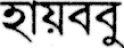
হায়ববু
